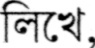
লিখে,
